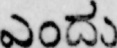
ಎಂದು
